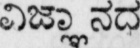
ವಿಜ್ಞಾನದ
